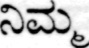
ನಿಮ್ಮ
